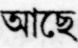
আছে
